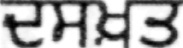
ਦਸਖ਼ਤ
